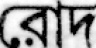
রোদ
